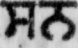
ਸਨ
